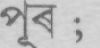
পূৰ;
